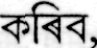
কৰিব,
